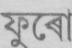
ফুৰো
